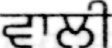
ਵਾਲੀ
